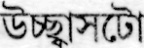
উচ্ছ্বাসটো
